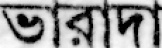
ভারাদা
